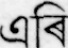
এৰি
